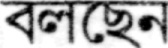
বলছেন
